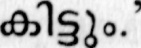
കിട്ടും.’
